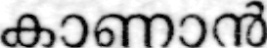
കാണാന്‍
